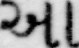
આ
